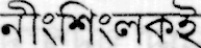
নীংশিংলকই
